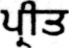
ਪ੍ਰੀਤ
